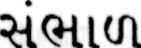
સંભાળ
